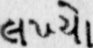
લખ્યો
